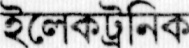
ইলেকট্রনিক
